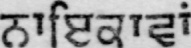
ਨਾਇਕਾਵਾਂ
